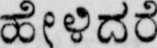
ಹೇಳಿದರೆ
